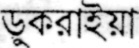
ডুকরাইয়া
